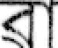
ৱা
